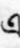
এ
